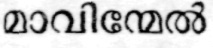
മാവിന്മേല്‍
